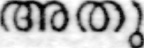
അതു
